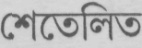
শেতেলিত
